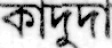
কাদুদা
